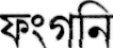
ফংগনি
